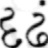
દૃઢં
